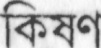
কিষণ
